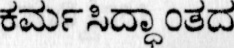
ಕರ್ಮಸಿದ್ಧಾಂತದ
